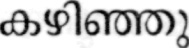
കഴിഞ്ഞു
